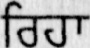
ਰਿਹਾ
